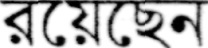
রয়েছেন
